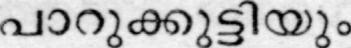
പാറുക്കുട്ടിയും
